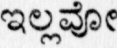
ಇಲ್ಲವೋ
